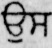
ਉਸ
